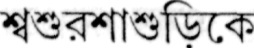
শ্বশুরশাশুড়িকে
